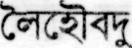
লৈহৌবদু
